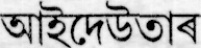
আইদেউতাৰ
